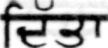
ਦਿੱਤਾ
